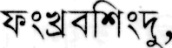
ফংখ্রবশিংদু,
